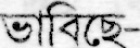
ভাবিছে-
